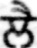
ਲੈ
